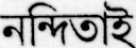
নন্দিতাই
